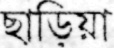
ছাড়িয়া
